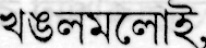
খঙলমলোই,
